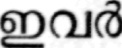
ഇവര്‍
